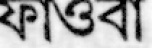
ফাওবা
